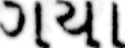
ગયા
